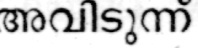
അവിടുന്ന്
